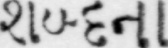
શબ્દના
